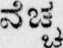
ವೆಚ್ಚ
